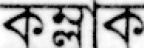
কম্লাক
